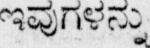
ಇವುಗಳನ್ನು
